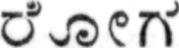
ರೋಗ
